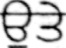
ਉਤੇ
